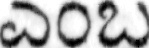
ಎಂಬ
